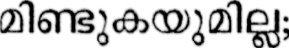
മിണ്ടുകയുമില്ല;
